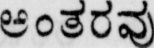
ಅಂತರವು
